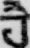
ਹੈ
